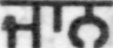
ਜਾਨ
